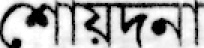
শোয়দনা
